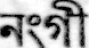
নংগী
